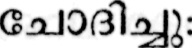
ചോദിച്ചു:
